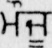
ਮੌਜੂ
